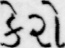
કેરો
